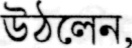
উঠলেন,
